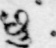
છું.
